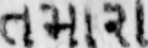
તમારા
